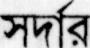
সর্দার
